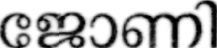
ജോണി
